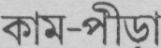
কাম-পীড়া
